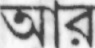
আর
